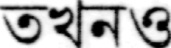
তখনও
